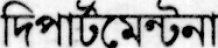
দিপার্টমেন্টনা
